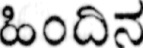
ಹಿಂದಿನ
